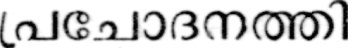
പ്രചോദനത്തി
